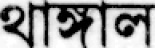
থাঙ্গাল
